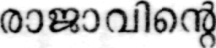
രാജാവിന്റെ
